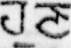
ਹੁਣ
